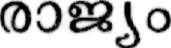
രാജ്യം
